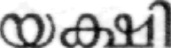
യക്ഷി
